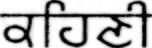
ਕਹਿਣੀ
